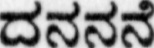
ದನನನೆ
